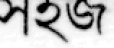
সহজ
